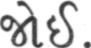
જોઈ.
